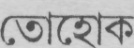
তোহোক
